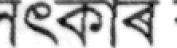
সৎকাৰ
